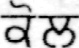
ਕੋਲ
